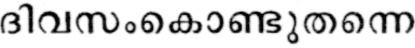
ദിവസംകൊണ്ടുതന്നെ
